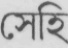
সেহি
